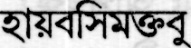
হায়বসিমক্তবু
